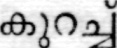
കുറച്ച്
